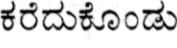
ಕರೆದುಕೊಂಡು
